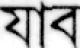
যাব
